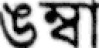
ঙম্বা
